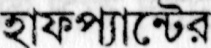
হাফপ্যান্টের
